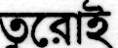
তুরোই
